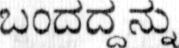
ಬಂದದ್ದನ್ನು
